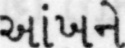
આંખને
